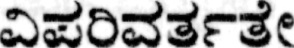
ವಿಪರಿವರ್ತತೇ
